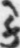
કે
